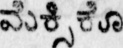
ಮೆಕ್ಸಿಕೊ
